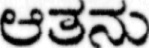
ಆತನು
